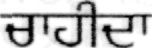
ਚਾਹੀਦਾ
